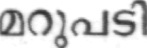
മറുപടി
